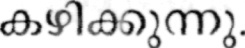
കഴിക്കുന്നു.
